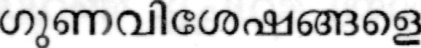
ഗുണവിശേഷങ്ങളെ
